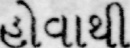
હોવાથી
